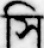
সি
